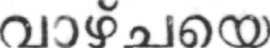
വാഴ്ചയെ
